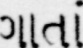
ગાતાં
